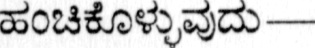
ಹಂಚಿಕೊಳ್ಳುವುದು-
